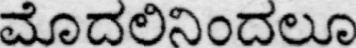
ಮೊದಲಿನಿಂದಲೂ
